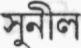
সুনীল
